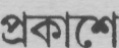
প্ৰকাশে
